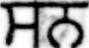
ਸਨ
